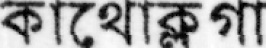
কাথোক্লগা
